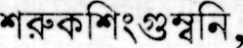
শরুকশিংগুম্বনি,
